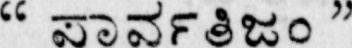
“ಪಾರ್ವತಿಜಂ”
